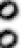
ঃ
